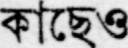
কাছেও
